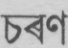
চৰণ
